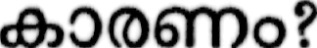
കാരണം?
